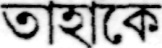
তাহাকে
